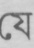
যে
